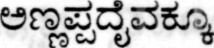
ಅಣ್ಣಪ್ಪದೈವಕ್ಕೂ
